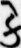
કે
